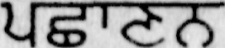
ਪਛਾਣਨ
